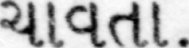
ચાવતા.
